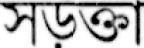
সড়ক্তা
